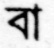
বা
